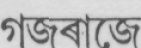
গজৰাজে
